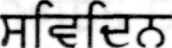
ਸਵਿਦਿਨ
